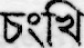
চংখি
